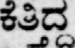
ಕೆತ್ತಿದ್ದ
